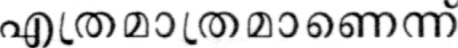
എത്രമാത്രമാണെന്ന്
